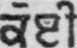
ਕੋਈ
